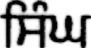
ਸਿੰਘ
